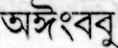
অঈংববু
